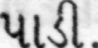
પાડી.
